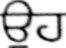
ਉਹ
